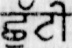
ਛੁੱਟੀ
